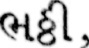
ભઠ્ઠી,
